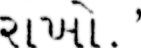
રાખો.
